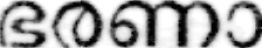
ഭരണാ
